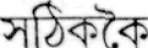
সঠিককৈ
